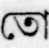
তো
